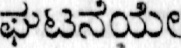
ಘಟನೆಯೇ
